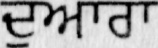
ਦੁਆਰਾ
